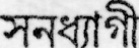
সনধ্যাগী
